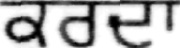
ਕਰਦਾ
